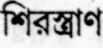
শিরস্ত্রাণ
